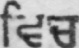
ਵਿਚ
